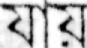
যায়
